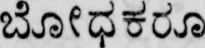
ಬೋಧಕರೂ
